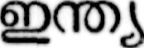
ഇന്ത്യ
